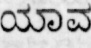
ಯಾವ
